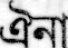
ঐনা
